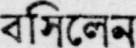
বসিলেন
